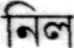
নিল
